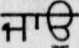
ਜਾਉ
